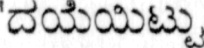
‘ದಯೆಯಿಟ್ಟು
